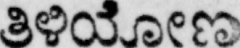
ತಿಳಿಯೋಣ
